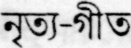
নৃত্য-গীত
